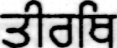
ਤੀਰਥਿ
